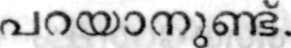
പറയാനുണ്ട്.
